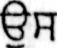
ਉਸ
